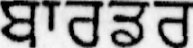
ਬਾਰਡਰ
